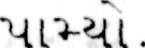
પામ્યો.
